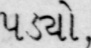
પડયો,
